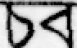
চব
